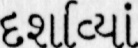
દર્શાવ્યા
